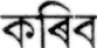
কৰিব
